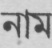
নাম
